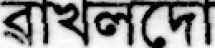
ৱাখলদো
